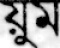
য়ুম
